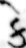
કે
